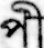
পী
